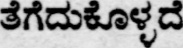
ತೆಗೆದುಕೊಳ್ಳದೆ
